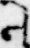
ને
